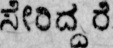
ಸೇರಿದ್ದರೆ
